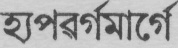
হ্যপৱৰ্গমাৰ্গে
